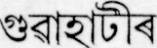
গুৱাহাটীৰ
